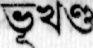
ভূখণ্ড
